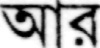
আর
